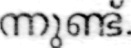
ന്നുണ്ട്.
